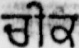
ਚੀਕ
